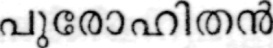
പുരോഹിതന്‍
